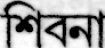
শিবনা
